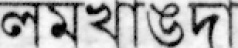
লমখাঙদা
